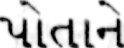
પોતાને
